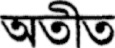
অতীত
